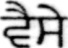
ਵੈਸੇ
